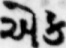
એક
